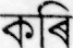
কৰি
